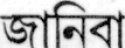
জানিবা
